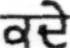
ਕਦੇ
